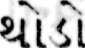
થોડો
